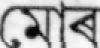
মোৰ
